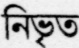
নিভৃত
